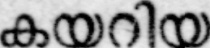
കയറിയ
